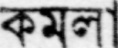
কমলা
